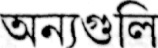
অন্যগুলি
